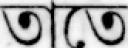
তাতে
